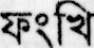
ফংখি
